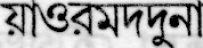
য়াওরমদদুনা
